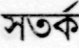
সতর্ক
